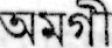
অমগী
